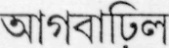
আগবাঢ়িল
